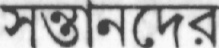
সন্তানদের
